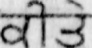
ਕੀਤੇ
